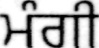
ਮੰਗੀ
